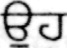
ਉਹ
